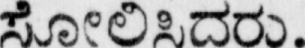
ಸೋಲಿಸಿದರು.
